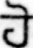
ਹੋ
